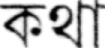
কথা
